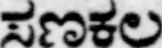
ಸಣಕಲ
